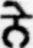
ਨੇ
